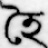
হৈ
